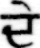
ਦੇ
